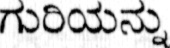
ಗುರಿಯನ್ನು
